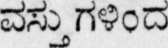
ವಸ್ತುಗಳಿಂದ
